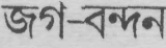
জগ-বন্দন
